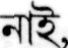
নাই,
